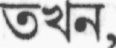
তখন,
